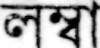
লম্বা
